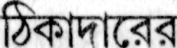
ঠিকাদারের
